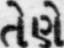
તેણે
